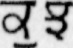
ਕੁਝ
